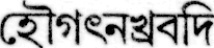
হৌগৎনখ্রবদি
